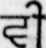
ਵੀ
